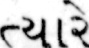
ત્યારે
